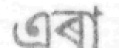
এৰা
